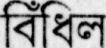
বিঁধিল
